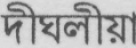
দীঘলীয়া
